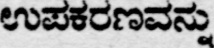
ಉಪಕರಣವನ್ನು
